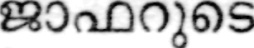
ജാഫറുടെ
